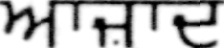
ਆਜ਼ਾਦ
